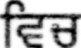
ਵਿਚ
